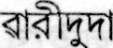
ৱারীদুদা
